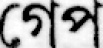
গেপ
